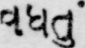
વધતું
